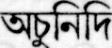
অচুনিদি
